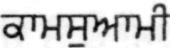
ਕਾਮਸੁਆਮੀ
